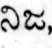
ನಿಜ,
